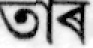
তাৰ
